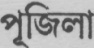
পূজিলা
